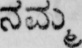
ನಮ್ಮ
